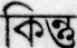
কিন্তু
